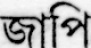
জাপি
